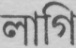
লাগি
